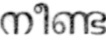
നീണ്ട
